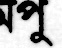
মপু
